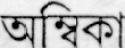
অম্বিকা
